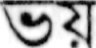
ভয়
